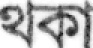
থকা
